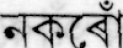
নকৰোঁ
